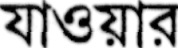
যাওয়ার
